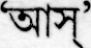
'আস'
